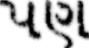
પણ
